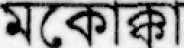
মকোক্কা
